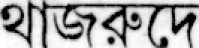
থাজরুদে
